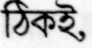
ঠিকই,
